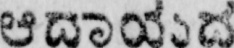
ಆದಾಯದ
